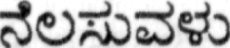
ನೆಲಸುವಳು
